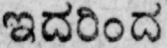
ಇದರಿಂದ
